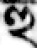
হু
